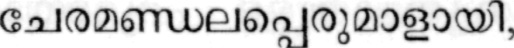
ചേരമണ്ഡലപ്പെരുമാളായി,
